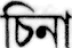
চিনা
